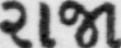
રાજા
